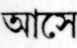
আসে
